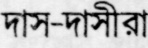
দাস-দাসীরা
